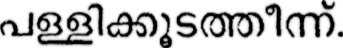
പള്ളികൂടത്തീന്ന്.
